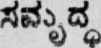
ಸಮೃದ್ಧ
